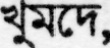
খুমদে,
